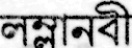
লম্লানবী
